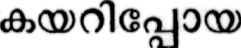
കയറിപ്പോയ
